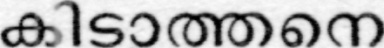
കിടാത്തനെ
